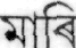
মাৰি
